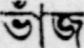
ভাঁজ
